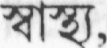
স্বাস্থ্য,
